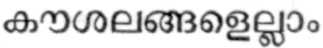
കൌശലങ്ങളെല്ലാം
